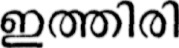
ഇത്തിരി
